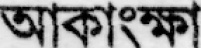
আকাংক্ষা
